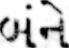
બંને
